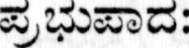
ಪ್ರಭುಪಾದ:
